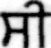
ਸੀ
